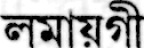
লমায়গী
